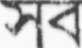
সব
